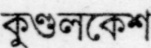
কুণ্ডলকেশ
